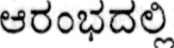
ಆರಂಭದಲ್ಲಿ
